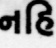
નહિ
